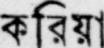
করিয়া
